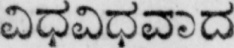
ವಿಧವಿಧವಾದ
